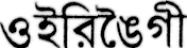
ওইরিঙৈগী
